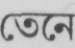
তেনে
